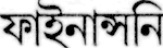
ফাইনান্সনি
